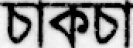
চাকচা
